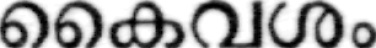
കൈവശം
